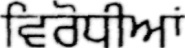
ਵਿਰੋਧੀਆਂ
